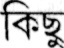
কিছু
